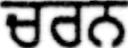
ਚਰਨ
